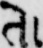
તો
